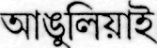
আঙুলিয়াই
